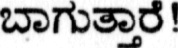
ಬಾಗುತ್ತಾರೆ!
